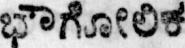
ಭೌಗೋಲಿಕ
